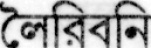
লৈরিবনি
